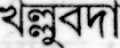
খল্লুবদা
